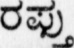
ರಫ್ತು
